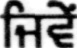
ਜਿਵੇਂ
